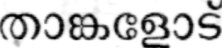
താങ്കളോട്
